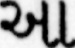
આ
